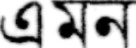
এমন
